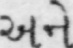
અને
